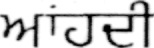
ਆਂਹਦੀ
